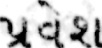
પ્રવેશ
